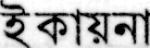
ইকায়না
